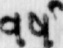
વર્ષ
